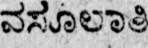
ವಸೂಲಾತಿ
